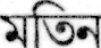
মতিন
